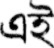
এই
